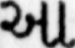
આ
